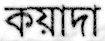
কয়াদা
